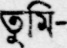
তুমি-
